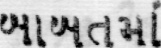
બાબતમાં
